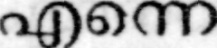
എന്നെ
